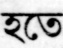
হতে
